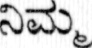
ನಿಮ್ಮ
